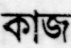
কাজ
